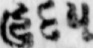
હદય
